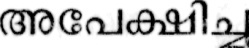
അപേക്ഷിച്ച
